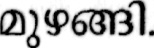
മുഴങ്ങി.
